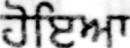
ਹੋਇਆ
